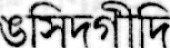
ঙসিদগীদি
